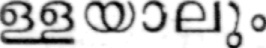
ള്ളയാലും
